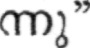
ന്നു”
